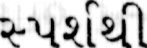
સ્પર્શથી
